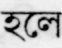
হলে
